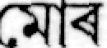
মোৰ
